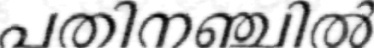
പതിനഞ്ചില്‍
